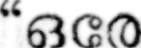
“ഒരേ
